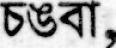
চঙবা,
